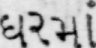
ઘરમાં
